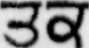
ਤਕ
